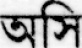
অসি
